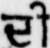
ਦੀ
